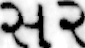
સર
